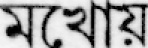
মখোয়
